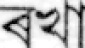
ৰখা
